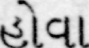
હોવા
